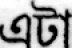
এটা
